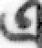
এ
